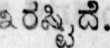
೩ರಷ್ಟಿದೆ.
